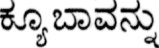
ಕ್ಯೂಬಾವನ್ನು
